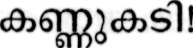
കണ്ണുകടി!
